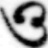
ও
